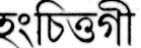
হংচিত্তগী
